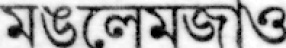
মঙলেমজাও
